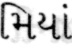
મિયાં
